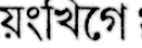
য়েংখিগে
